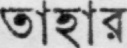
তাহার
